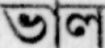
ভাল
